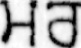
ਮਰ
